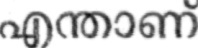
എന്താണ്
